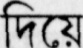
দিয়ে
